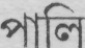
পালি
